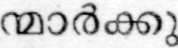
ന്മാര്‍ക്കു
